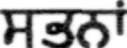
ਸਭਨਾਂ
